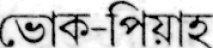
ভোক-পিয়াহ
